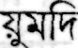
য়ুমদি
